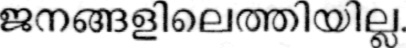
ജനങ്ങളിലെത്തിയില്ല.
